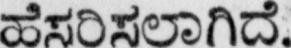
ಹೆಸರಿಸಲಾಗಿದೆ.
